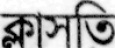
ক্লাসতি
